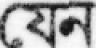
যেন
